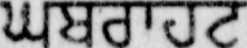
ਘਬਰਾਹਟ
